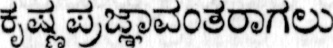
ಕೃಷ್ಣಪ್ರಜ್ಞಾವಂತರಾಗಲು
